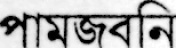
পামজবনি
